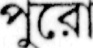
পুরো
